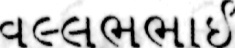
વલ્લભભાઈ
